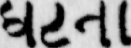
ધટના
